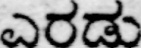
ಎರಡು
